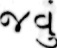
જવું
